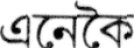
এনেকৈ
